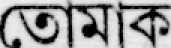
তোমাক
